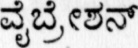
ವೈಬ್ರೇಶನ್
